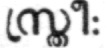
സ്ത്രീ:
